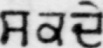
ਸਕਦੇ
